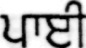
ਪਾਈ
